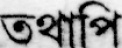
তথাপি
